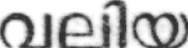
വലിയ
